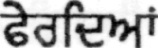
ਫੇਰਦਿਆਂ
